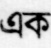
এক
